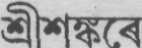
শ্ৰীশঙ্কৰে
